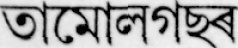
তামোলগছৰ
